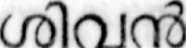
ശിവന്‍
